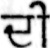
ਦੀ
